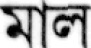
মাল
